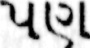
પણ
